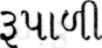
રૂપાળી
